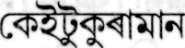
কেইটুকুৰামান
